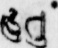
હતું
